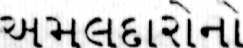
અમલદારોનો
